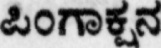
ಪಿಂಗಾಕ್ಷನ
